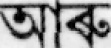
আৰু
